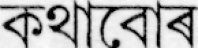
কথাবোৰ
